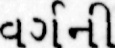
વર્ગની
